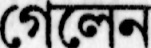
গেলেন
